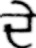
ਦੇ
